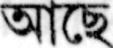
আছে
